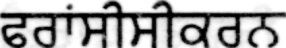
ਫਰਾਂਸੀਸੀਕਰਨ
